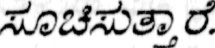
ಸೂಚಿಸುತ್ತಾರೆ.
